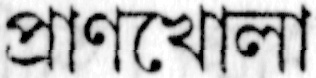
প্রাণখোলা
